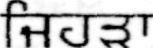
ਜਿਹੜਾ
